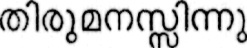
തിരുമനസ്സിന്നു
